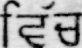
ਵਿਚ
